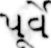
પૂર્વે
